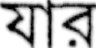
যার
